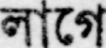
লাগে
